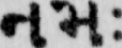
નમઃ
